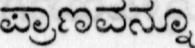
ಪ್ರಾಣವನ್ನೂ
